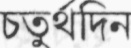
চতুর্থদিন
